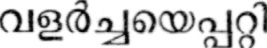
വളര്‍ച്ചയെപ്പറ്റി
